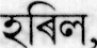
হৰিল,
